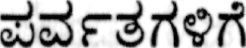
ಪರ್ವತಗಳಿಗೆ
